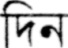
দিন
